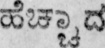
ಹೆಚ್ಚಾದ
